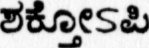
ಶಕ್ತೋsಪಿ
